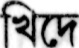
খিদে
